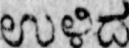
ಉಳಿದ
